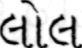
લોલ
